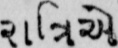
રાત્રિએ
